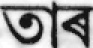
তাৰ
